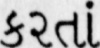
કરતાં
